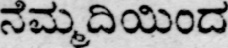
ನೆಮ್ಮದಿಯಿಂದ
